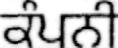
ਕੰਪਨੀ
